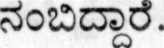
ನಂಬಿದ್ದಾರೆ.
